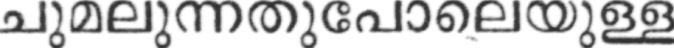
ചുമലുന്നതുപോലെയുള്ള
